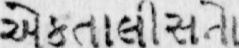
એકતાલીસનો
